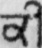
ਕੀ
